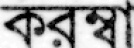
করম্বা
